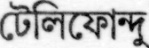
টেলিফোন্দু
